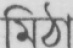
মিঠা
